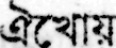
ঐখোয়
